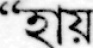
“হায়
